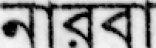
নারবা
